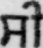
ਸੀ
